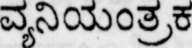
ವ್ಯನಿಯಂತ್ರಕ
